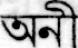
অনী
